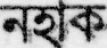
নহাক
